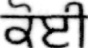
ਕੋਈ
